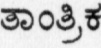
ತಾಂತ್ರಿಕ
